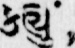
કહ્યું,
